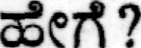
ಹೇಗೆ?
